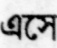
এসে
